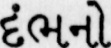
દંભનો
